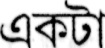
একটা
